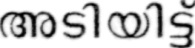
അടിയിട്ട്
